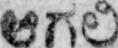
ಆಗಲಿ
